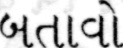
બતાવો
